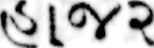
હાજર
